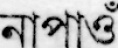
নাপাওঁ
